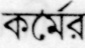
কর্মের
